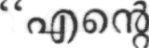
"എന്റെ
